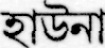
হাউনা
